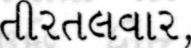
તીરતલવાર,
